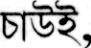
চাউই,
